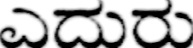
ಎದುರು
